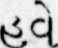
હવે
